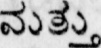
ಮತ್ತು
